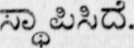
ಸ್ಥಾಪಿಸಿದೆ.
